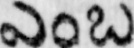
ಎಂಬ
